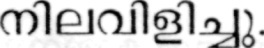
നിലവിളിച്ചു.
